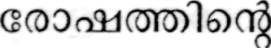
രോഷത്തിന്റെ
